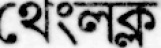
থেংলক্লে
